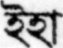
ইহা
